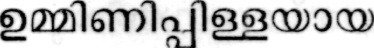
ഉമ്മിണിപ്പിള്ളയായ
